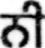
ਨੀ
